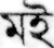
মই
